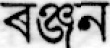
ৰঞ্জন
